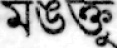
মঙক্তু
